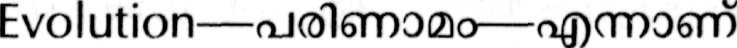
Evolution-പരിണാമം-എന്നാണ്
